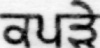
ਕਪੜੇ
